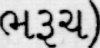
ભરૂચ)
